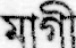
মাগী
